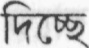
দিচ্ছে
